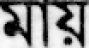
মায়
